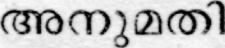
അനുമതി
